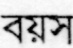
বয়স
